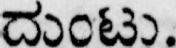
ದುಂಟು.
